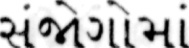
સંજોગોમાં
